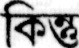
কিন্তু
